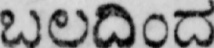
ಬಲದಿಂದ
